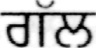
ਗੱਲ
